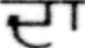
ਦਾ
